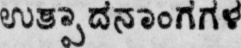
ಉತ್ಪಾದನಾಂಗಗಳ
